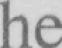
he
